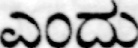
ಎಂದು
